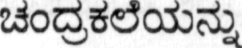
ಚಂದ್ರಕಲೆಯನ್ನು
